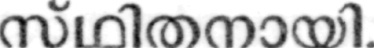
സ്ഥിതനായി.
